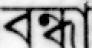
বন্ধা
